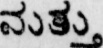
ಮತ್ತು
